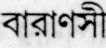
বারাণসী
